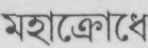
মহাক্ৰোধে
